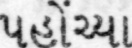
પહોંચ્યા
